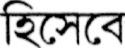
হিসেবে
